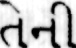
તેની
